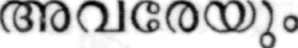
അവരേയും
